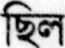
ছিল
